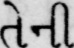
તેની
